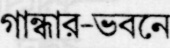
গান্ধার-ভবনে
